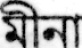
মীনা
